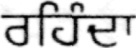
ਰਹਿੰਦਾ
